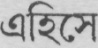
এহিসে
